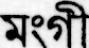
মংগী
